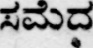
ಸಮೆದ
